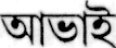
আভাই
